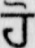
ਹੋ
